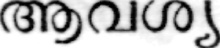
ആവശ്യ
